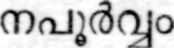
നപൂര്‍വ്വം
